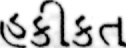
હકીકત
